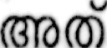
അത്
